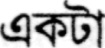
একটা
